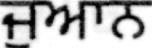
ਜੁਆਨ
